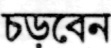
চড়বেন
